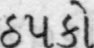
ઠપકો
